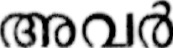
അവര്‍
